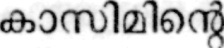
കാസിമിന്റെ
